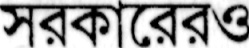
সরকারেরও
